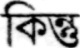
কিন্তু
